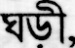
ঘড়ী,
